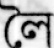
লৈ
